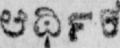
ಆರ್ಥಿಕ
